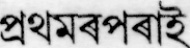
প্রথমৰপৰাই
